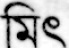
মিৎ
